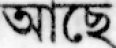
আছে
